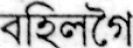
বহিলগৈ
